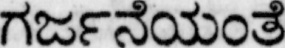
ಗರ್ಜನೆಯಂತೆ
